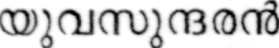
യുവസുന്ദരന്‍
